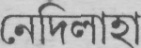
নেদিলাহা
